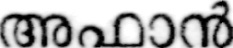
അഫാന്‍
